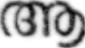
ആ
